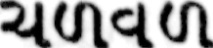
ચળવળ
